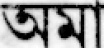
অমা
